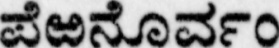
ಪೆಱನೊರ್ವಂ
